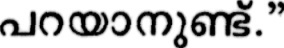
പറയാനുണ്ട്.”
